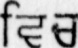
ਵਿਚ
